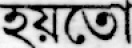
হয়তো
